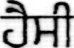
ਹੈਸੀ
